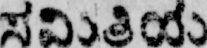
ಸಮಿತಿಯ
